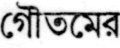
গৌতমের
